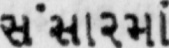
સંસારમાં
